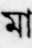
মা
